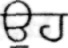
ਉਹ
